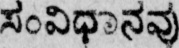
ಸಂವಿಧಾನವು
